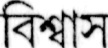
বিশ্বাস
